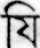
যি
